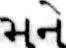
મને
